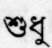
শুধু
